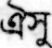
ঐসু
